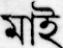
মাই
